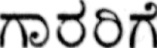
ಗಾರರಿಗೆ
